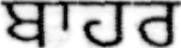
ਬਾਹਰ
